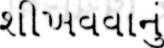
શીખવવાનું
